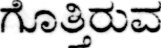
ಗೊತ್ತಿರುವ
